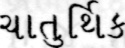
ચાતુર્થિક
